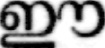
ഈ
